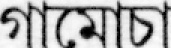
গামোচা
